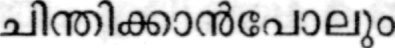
ചിന്തിക്കാന്‍പോലും
